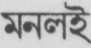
মনলই
